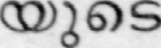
യുടെ
